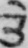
ਤੇ
